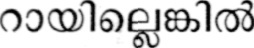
റായില്ലെങ്കില്‍
